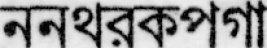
ননথরকপগা
